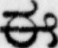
ಈ
